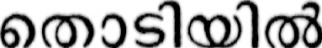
തൊടിയില്‍
